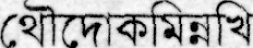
থৌদোকমিন্নখি
